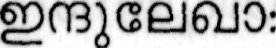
ഇന്ദുലേഖാ:
